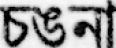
চঙনা
